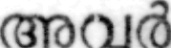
അവര്‍
